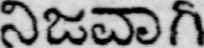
ನಿಜವಾಗಿ
